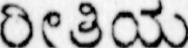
ರೀತಿಯ
